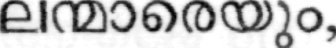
ലന്മാരെയും,
